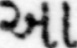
આ
